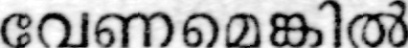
വേണമെങ്കില്‍
